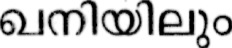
ഖനിയിലും
